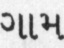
ગામ
